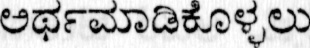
ಅರ್ಥಮಾಡಿಕೊಳ್ಳಲು
